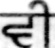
ਵੀ
